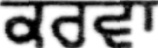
ਕਰਵਾ
